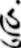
હું
